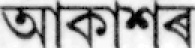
আকাশৰ
